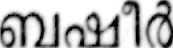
ബഷീര്‍
